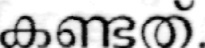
കണ്ടത്.
